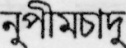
নুপীমচাদু
